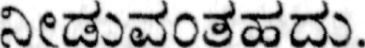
ನೀಡುವಂತಹದು.
